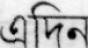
এদিন
